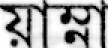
য়াম্না
